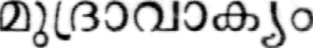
മുദ്രാവാക്യം
